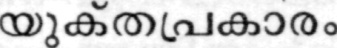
യുക്തപ്രകാരം
